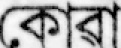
কোৱা
